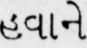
હવાને
